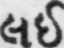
લઈ
